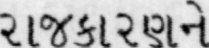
રાજકારણને
